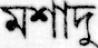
মশাদু
